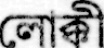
লোক্কী
